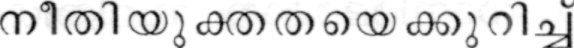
നീതിയുക്തതയെക്കുറിച്ച്
